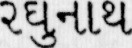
રઘુનાથ
